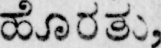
ಹೊರತು,
